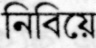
নিবিয়ে
